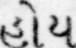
હોય
